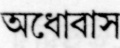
অধোবাস
